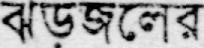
ঝড়জলের
